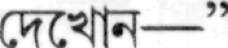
দেখোন-"
